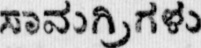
ಸಾಮಗ್ರಿಗಳು
